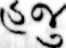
હજુ
